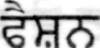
ਫੈਸ਼ਨ
